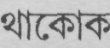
থাকোক
